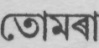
তোমৰা
